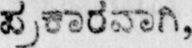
ಪ್ರಕಾರವಾಗಿ,
